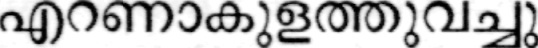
എറണാകുളത്തുവച്ചു
